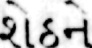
શેઠને
